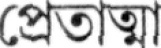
প্রেতাত্মা
